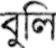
বুলি
